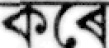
কৰে
